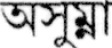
অসুম্না
